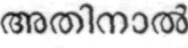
അതിനാല്‍
